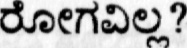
ರೋಗವಿಲ್ಲ?
